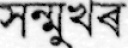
সন্মুখৰ
